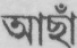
আছাঁ
